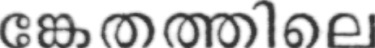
ങ്കേതത്തിലെ
